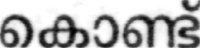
കൊണ്ട്
